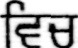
ਵਿਚ
